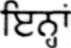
ਇਨ੍ਹਾਂ
